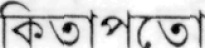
কিতাপতো
